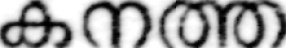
കനത്ത
